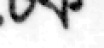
চেক
